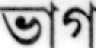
ভাগ
